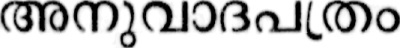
അനുവാദപത്രം
